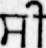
ਸੀ
